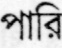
পারি
